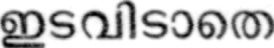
ഇടവിടാതെ
